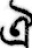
ঐ
